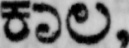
ಕಾಲ,
